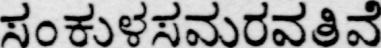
ಸಂಕುಳಸಮರವತಿವೆ
